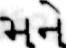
મને
